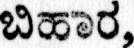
ಬಿಹಾರ,
